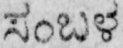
ಸಂಬಳ
